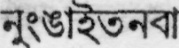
নুংঙাইতনবা
